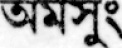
অমসুং
